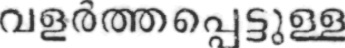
വളര്‍ത്തപ്പെട്ടുള്ള
